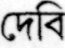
দেবি
